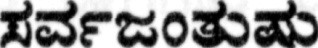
ಸರ್ವಜಂತುಷು
